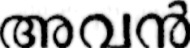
അവന്‍
